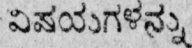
ವಿಷಯಗಳನ್ನು
